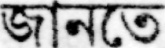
জানতে
